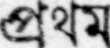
প্রথম
